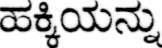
ಹಕ್ಕಿಯನ್ನು
